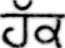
ਹੱਕ
